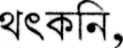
থৎকনি,
